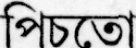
পিচতো
